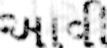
આવી
